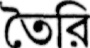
তৈরি
